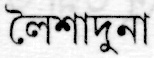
লৈশাদুনা
